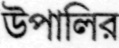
উপালির
